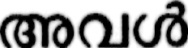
അവള്‍
